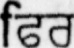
ਫਿਰ
